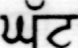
ਘੱਟ
